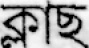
ক্লাছ
